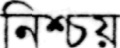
নিশ্চয়
